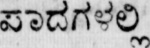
ಪಾದಗಳಲ್ಲಿ
